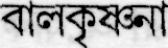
বালকৃষ্ণনা
